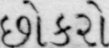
છોકરો
